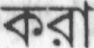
করা
